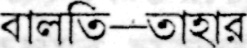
বালতি—তাহার
